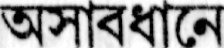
অসাবধানে
